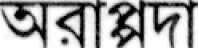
অরাপ্পদা
